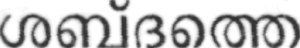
ശബ്ദത്തെ
